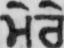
ਮੇਰੇ
